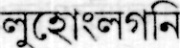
লুহোংলগনি
